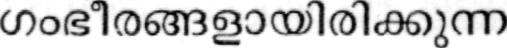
ഗംഭീരങ്ങളായിരിക്കുന്ന
